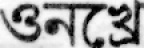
ওনখ্রে
